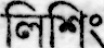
লিশিং
